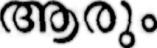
ആരും
